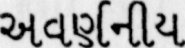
અવર્ણનીય
